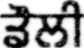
ਡੌਲੀ
